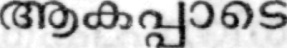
ആകപ്പാടെ
